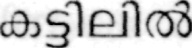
കട്ടിലില്‍
